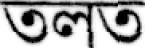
তলত
